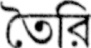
তৈরি
